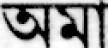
অমা
